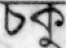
চকু
